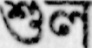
শুল
